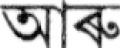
আৰু
